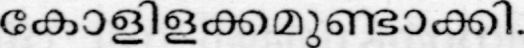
കോളിളക്കമുണ്ടാക്കി.
